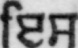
ਇਸ
